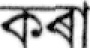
কৰা
